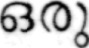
ഒരു
